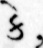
કે,
